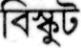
বিস্কুট
